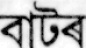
বাটৰ
